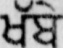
ਖੱਬੇ
